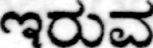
ಇರುವ
